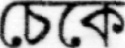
চেকে
